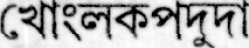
খোংলকপদুদা
